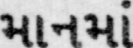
માનમાં
